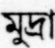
মুদ্রা
